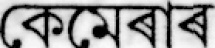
কেমেৰাৰ
